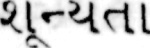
શૂન્યતા
